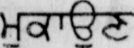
ਮੁਕਾਉਣ
